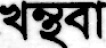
খন্থবা
